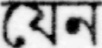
যেন
